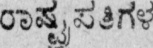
ರಾಷ್ಟ್ರಪತಿಗಳ
